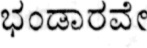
ಭಂಡಾರವೇ
